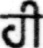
ਹੀ
